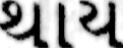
થાય
